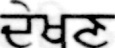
ਦੇਖਣ
